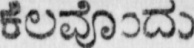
ಕೆಲವೊಂದು
